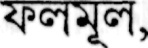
ফলমূল,
